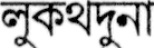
লুকথদুনা
